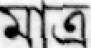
মাত্র
